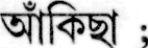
আঁকিছা;
